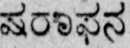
ಷರಾಫನ
